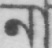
না
